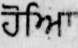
ਹੋਅਿਾ
